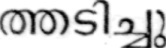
ത്തടിച്ചു
